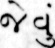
જેવું
